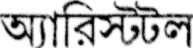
অ্যারিস্টটল
